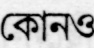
কোনও
